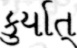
કુર્યાત્
